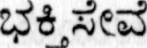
ಭಕ್ತಿಸೇವೆ
